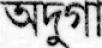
অদুগা
